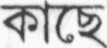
কাছে
